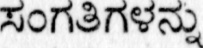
ಸಂಗತಿಗಳನ್ನು
